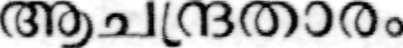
ആചന്ദ്രതാരം
